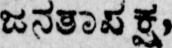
ಜನತಾಪಕ್ಷ,
